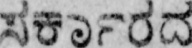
ಸರ್ಕಾರದ
